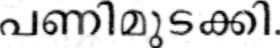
പണിമുടക്കി.
